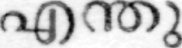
എന്തു
